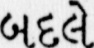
બદલે
